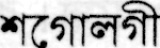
শগোলগী
